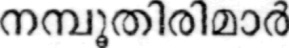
നമ്പൂതിരിമാര്‍
